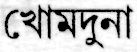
খোমদুনা
